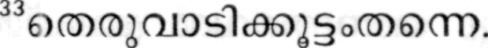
33തെരുവാടിക്കൂട്ടംതന്നെ.
